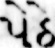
પેઠે
